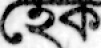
হেক
